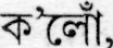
ক'লোঁ,
